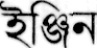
ইঞ্জিন
